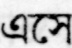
এসে
